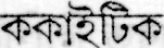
ককাইটিক
